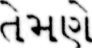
તેમણે
